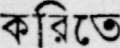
করিতে
